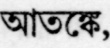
আতঙ্কে,
